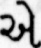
એ
